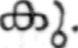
കു.
